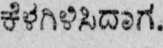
ಕೆಳಗಿಳಿಸಿದಾಗ.
